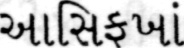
આસિફખાં
